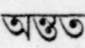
অন্তত
